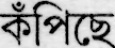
কঁপিছে
